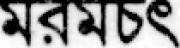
মরমচৎ
